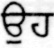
ਉਹ
